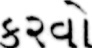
કરવો
